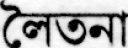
লৈতনা
